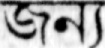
জন্য
